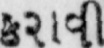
કરાવી
